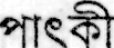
পাৎকী
